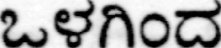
ಒಳಗಿಂದ
